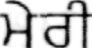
ਮੇਰੀ
